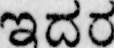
ಇದರ
